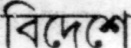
বিদেশে
